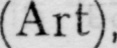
(Art),
